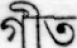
গীত
